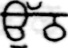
ਉੱਠ
